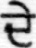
ਦੇ
